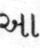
આ
